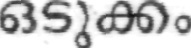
ഒടുക്കം
